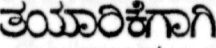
ತಯಾರಿಕೆಗಾಗಿ
